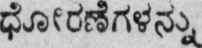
ಧೋರಣೆಗಳನ್ನು
